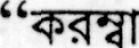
“করম্বা
